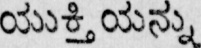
ಯುಕ್ತಿಯನ್ನು
